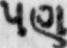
પણ
